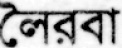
লৈরবা
